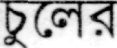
চুলের
